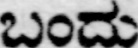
ಬ೦ದು
